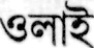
ওলাই
